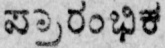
ಪ್ರಾರಂಭಿಕ
